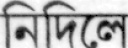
নিদিলে
